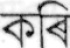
কৰি
